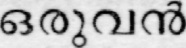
ഒരുവന്‍
